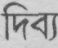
দিব্য
